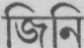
জিনি
